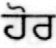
ਹੋਰ
